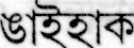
ঙাইহাক
